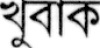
খুবাক
